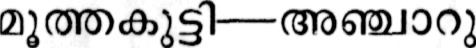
മൂത്തകുട്ടി-അഞ്ചാറു
